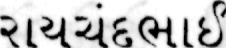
રાયચંદભાઇ
